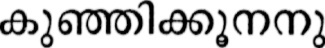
കുഞ്ഞിക്കൂനനു
